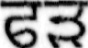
ਫੜ
